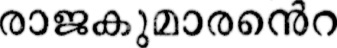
രാജകുമാരന്റെ
